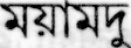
ময়ামদু
